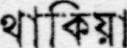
থাকিয়া
